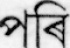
পৰি
